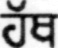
ਹੱਥ
